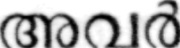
അവര്‍
